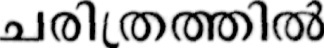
ചരിത്രത്തില്‍
